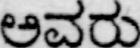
ಅವರು
